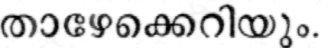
താഴേക്കെറിയും.
